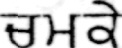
ਚਮਕੇ
